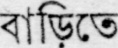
বাড়িতে
